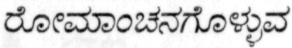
ರೋಮಾಂಚನಗೊಳ್ಳುವ
